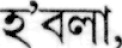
হ'বলা,
